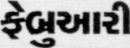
ફ્રેબ્રુઆરી
